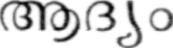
ആദ്യം
